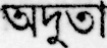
অদুতা
